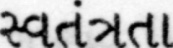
સ્વતંત્રતા
